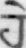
ਹੇ
